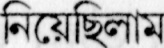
নিয়েছিলাম
